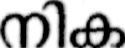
നിക
